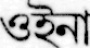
ওইনা
